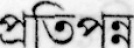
প্রতিপন্ন
